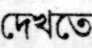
দেখতে
